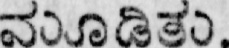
ಮೂಡಿತು.
